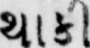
થાકી
